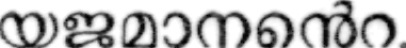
യജമാനന്റെ.
